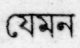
যেমন
